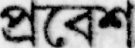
প্রবেশ
